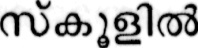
സ്കൂളില്‍
